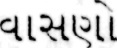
વાસણો
